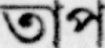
তাপ
